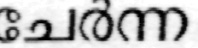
ചേര്‍ന്ന
